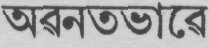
অৱনতভাৱে
